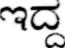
ಇದ್ದ
